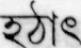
হঠাৎ
